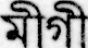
মীগী
